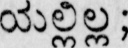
ಯಲ್ಲಿಲ್ಲ;
